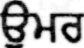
ਉਮਰ
